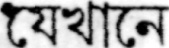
যেখানে
